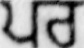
ਪਰ
